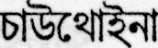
চাউথোইনা
